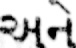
અને
